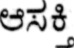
ಆಸಕ್ತಿ
